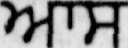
ਆਸ
